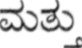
ಮತ್ತು
